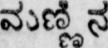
ಮಣ್ಣಿನ
